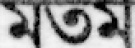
মতম
